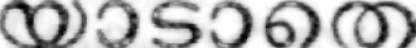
യാടാതെ
